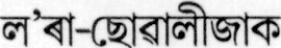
ল'ৰা-ছোৱালীজাক
